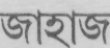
জাহাজ
